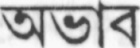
অভাব
